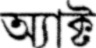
অ্যাক্ট
